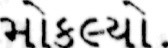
મોકલ્યો.
